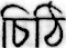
চিঠি
